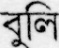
বুলি
